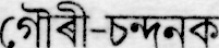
গৌৰী-চন্দনক
